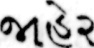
જાહેર
